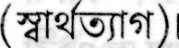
(স্বার্থত্যাগ)।
